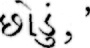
છોડું,'
